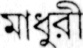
মাধুরী
